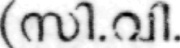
(സി.വി.
